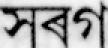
সৰগ
